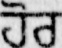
ਹੋਰ
